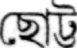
ছোট্ট
